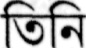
তিনি
